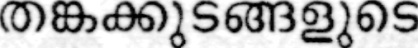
തങ്കക്കുടങ്ങളുടെ
